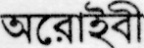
অরোইবী
